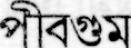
পীবগুম
